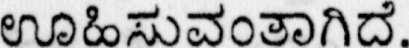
ಊಹಿಸುವಂತಾಗಿದೆ.
